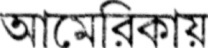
আমেরিকায়
